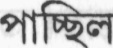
পাচ্ছিল
